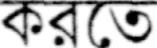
করতে
